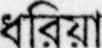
ধরিয়া
